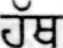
ਹੱਥ
